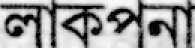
লাকপনা
